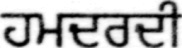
ਹਮਦਰਦੀ
